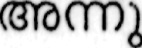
അന്നു
